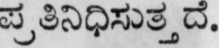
ಪ್ರತಿನಿಧಿಸುತ್ತದೆ.
